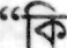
"কি
